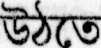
উঠতে
